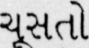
ચૂસતો
